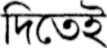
দিতেই
